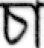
চা
